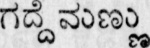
ಗದ್ದೆಮಣ್ಣು
